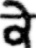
ਕੇ
